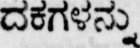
ದಕಗಳನ್ನು
